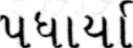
પધાર્યા
